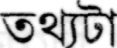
তথ্যটা
